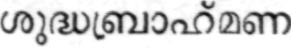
ശുദ്ധബ്രാഹ്മണ
